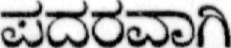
ಪದರವಾಗಿ
